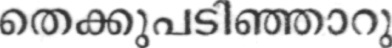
തെക്കുപടിഞ്ഞാറു
